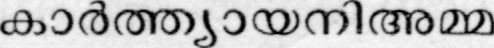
കാര്‍ത്ത്യായനിഅമ്മ
